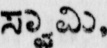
ಸ್ವಾಮಿ,
